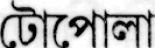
টোপোলা
